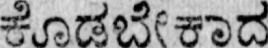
ಕೊಡಬೇಕಾದ
